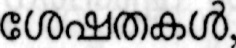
ശേഷതകള്‍,
